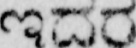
ಇದರ
